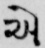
એ
